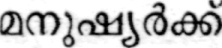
മനുഷ്യര്‍ക്ക്
